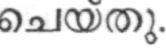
ചെയ്തു.
